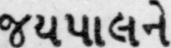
જયપાલને
